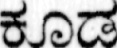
ಕೂಡ
